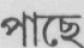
পাছে
